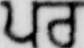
ਪਰ
